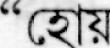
“হোয়
